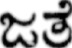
ಜತೆ
